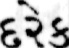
દરેક
